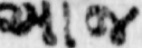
આજ
